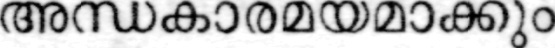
അന്ധകാരമയമാക്കും
